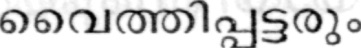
വൈത്തിപ്പട്ടരും
